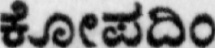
ಕೋಪದಿಂ
